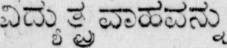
ವಿದ್ಯುತ್ಪ್ರವಾಹವನ್ನು
